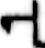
ન
